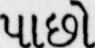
પાછો
